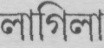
লাগিলা
